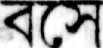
বসে
